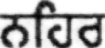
ਨਹਿਰ
